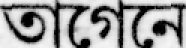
তাগেনে
